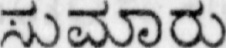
ಸುಮಾರು
